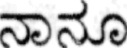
ನಾನೂ
